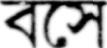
বসে
